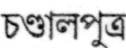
চণ্ডালপুত্র
